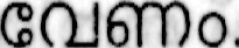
വേണം.
